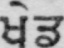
ਖੇਡ
